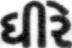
ધીરે
